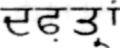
ਦਫ਼ਤ੍ਰਾਂ
